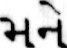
મને
